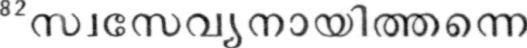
82സ്വസേവ്യനായിത്തന്നെ
